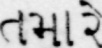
તમારે
